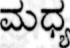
ಮಧ್ಯ
